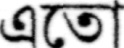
এতো
